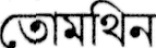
তোমথিন
